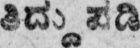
ತಿದ್ದುಪಡಿ
